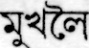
মুখলৈ
